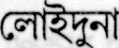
লোইদুনা
